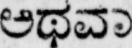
ಅಥವಾ
